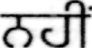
ਨਹੀਂ
